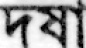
দষা
